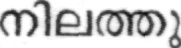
നിലത്തു
